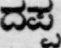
ದಪ್ಪ
